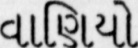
વાણિયો
